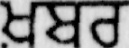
ਖ਼ਬਰ
